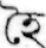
হৈ
